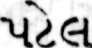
પટેલ
